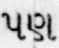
પણ
